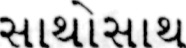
સાથોસાથ
